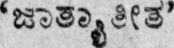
‘ಜಾತ್ಯಾತೀತ’
